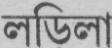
লড়িলা
